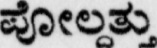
ಪೋಲ್ದತ್ತು
